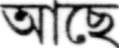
আছে
